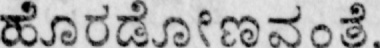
ಹೊರಡೋಣವಂತೆ.
